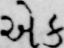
એક
